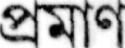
প্রমাণ
